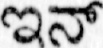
ಇನ್
